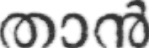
താന്‍
